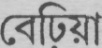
বেঢ়িয়া
